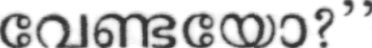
വേണ്ടയോ?"
